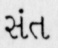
સંત
